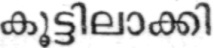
കൂട്ടിലാക്കി
